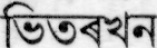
ভিতৰখন
